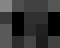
মরম
